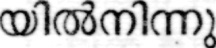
യില്‍നിന്നു
